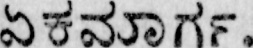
ಏಕಮಾರ್ಗ.
